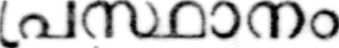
പ്രസ്ഥാനം
